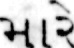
મારે
